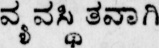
ವ್ಯವಸ್ಥಿತವಾಗಿ
